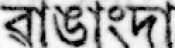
ৱাঙাংদা
